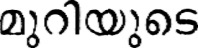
മുറിയുടെ
